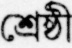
শ্রেষ্ঠী
